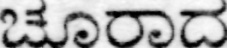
ಚೂರಾದ
